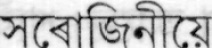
সৰোজিনীয়ে
